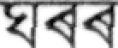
ঘৰৰ
